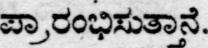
ಪ್ರಾರ೦ಭಿಸುತ್ತಾನೆ.
